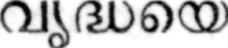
വൃദ്ധയെ
